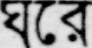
ঘরে
